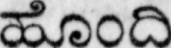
ಹೊಂದಿ
